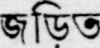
জড়িত
